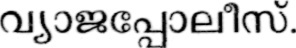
വ്യാജപ്പോലീസ്.
